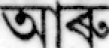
আৰু
